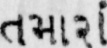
તમારાં
